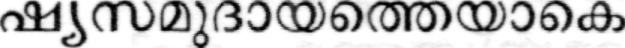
ഷ്യസമുദായത്തെയാകെ
